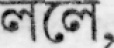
ললে,
